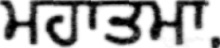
ਮਹਾਤਮਾ,
